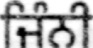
ਜਿੰਨੀ
